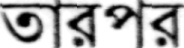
তারপর
